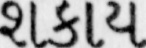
શકાય
